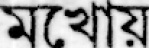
মখোয়
